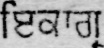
ਇਕਾਗ੍ਰ
